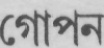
গোপন
